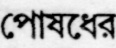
পোষধের
